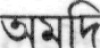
অমদি
